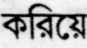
করিয়ে
